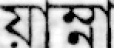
য়াম্না
